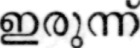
ഇരുന്ന്
